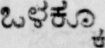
ಒಳಕ್ಕೂ
